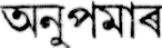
অনুপমাৰ
